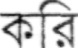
করি
